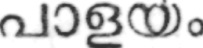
പാളയം
